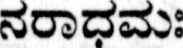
ನರಾಧಮಃ
